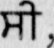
ਸੀ,
